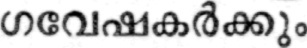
ഗവേഷകര്‍ക്കും
